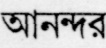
আনন্দর
